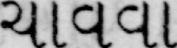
ચાવવા
